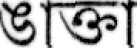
ঙাক্তা
